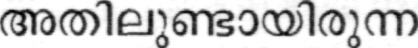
അതിലുണ്ടായിരുന്ന
